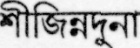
শীজিন্নদুনা
